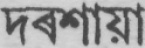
দৰশায়া
